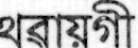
থৱায়গী
